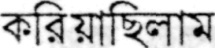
করিয়াছিলাম
